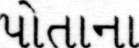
પોતાના
